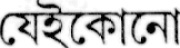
যেইকোনো
